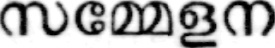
സമ്മേളന
